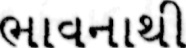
ભાવનાથી
